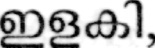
ഇളകി,
